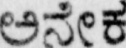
ಅನೇಕ
